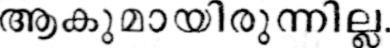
ആകുമായിരുന്നില്ല.
